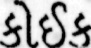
કોઈક
